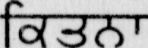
ਕਿਤਨਾ
